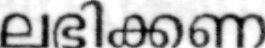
ലഭിക്കണ
